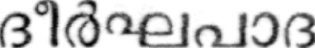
ദീര്‍ഘപാദ
